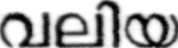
വലിയ
